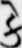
કે
